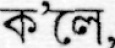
ক'লে,
